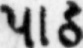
પાઠ
